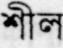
শীল
